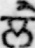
ਲੈ
